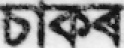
চাকৰ
